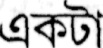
একটা
